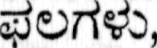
ಫಲಗಳು,
